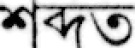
শব্দত
